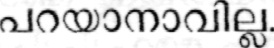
പറയാനാവില്ല.
